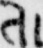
તો
